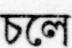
চলে
